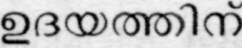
ഉദയത്തിന്
